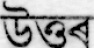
উত্তৰ
